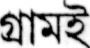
গ্রামই
